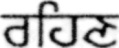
ਰਹਿਣ
